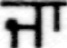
ਜਾ
